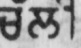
ਚੱਲੀ
